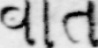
વાત
